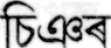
চিঞৰ
